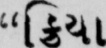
“ક્રિયા
